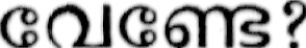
വേണ്ടേ?
